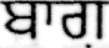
ਬਾਗ਼
